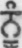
ਨੂੰ
